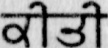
ਕੀਤੀ
